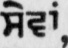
ਸੇਵਾਂ,
